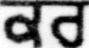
ਕਰ
